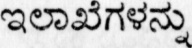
ಇಲಾಖೆಗಳನ್ನು
